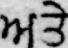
ਅਤੇ
